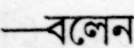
–বলেন
